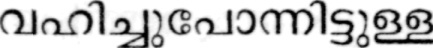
വഹിച്ചുപോന്നിട്ടുള്ള
